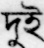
দুই
